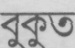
বুকুত
